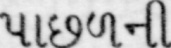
પાછળની
